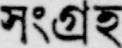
সংগ্রহ
